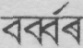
বৰ্ব্বৰ
